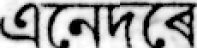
এনেদৰে
